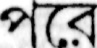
পরে
